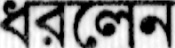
ধরলেন
